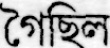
গৈছিল
